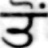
ਤੋਂ
